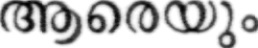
ആരെയും
